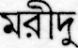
মরীদু
